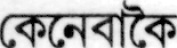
কেনেবাকৈ
